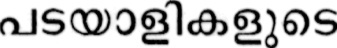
പടയാളികളുടെ
